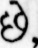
છે,
